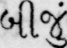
બીજું
